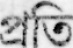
প্রতি
